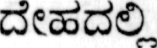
ದೇಹದಲ್ಲಿ
